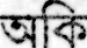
অকি
